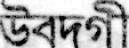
উবদগী
